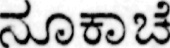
ನೂಕಾಚೆ
